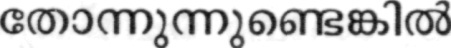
തോന്നുന്നുണ്ടെങ്കില്‍
